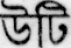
উটি
